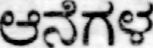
ಆನೆಗಳ
